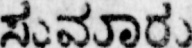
ಸುಮಾರು
